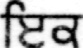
ਇਕ
